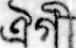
ঐগী
